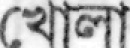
খোলা
